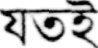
যতই
